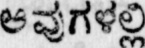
ಅವುಗಳಲ್ಲಿ
